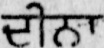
ਦੀਨਾ
